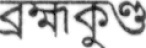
ব্রহ্মকুণ্ড
